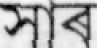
সাৰ
